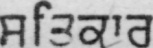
ਸਤਿਕਾਰ
